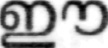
ഈ
